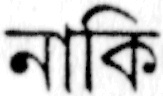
নাকি
